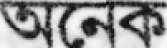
অনেক
